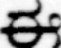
ಈ
